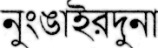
নুংঙাইরদুনা
